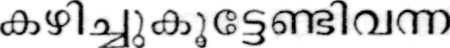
കഴിച്ചുകൂട്ടേണ്ടിവന്ന
